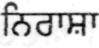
ਨਿਰਾਸ਼ਾ
